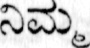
ನಿಮ್ಮ
